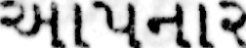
આપનાર
